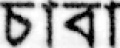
চাবা
